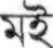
মই
